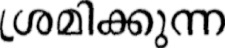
ശ്രമിക്കുന്ന
